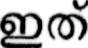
ഇത്
